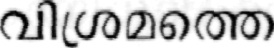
വിശ്രമത്തെ
